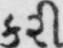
કરી
